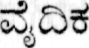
ವೈದಿಕ
